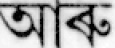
আৰু
